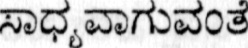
ಸಾಧ್ಯವಾಗುವಂತೆ
